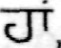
ਹਾਂ,
